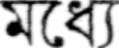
মধ্যে
